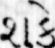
શકે
